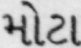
મોટા
